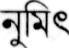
নুমিৎ
